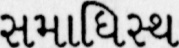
સમાધિસ્થ
